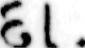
દા.
